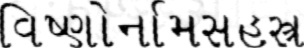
વિષ્ણોર્નામસહસ્ત્ર
